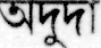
অদুদা
